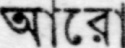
আরো
